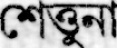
শেত্তুনা
